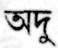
অদু
